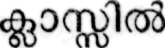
ക്ലാസ്സില്‍
